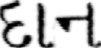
દાન
